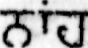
ਨਾਂਹ
